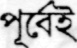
পূর্বেই
